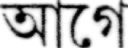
আগে
